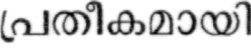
പ്രതീകമായി
